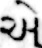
એ
